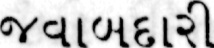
જવાબદારી
